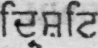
ਦ੍ਰਿਸ਼ਟਿ
